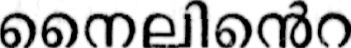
നൈലിന്റെ
